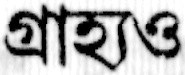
গ্রাহ্যও
